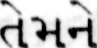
તેમને
